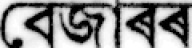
বেজাৰৰ
